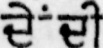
ਦੇਂਦੀ
